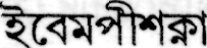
ইবেমপীশক্না
